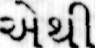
એથી
